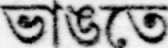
ভাঙতে
